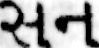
સન
